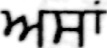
ਅਸਾਂ
